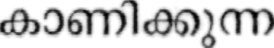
കാണിക്കുന്ന
